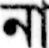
না
